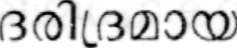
ദരിദ്രമായ
